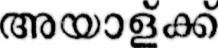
അയാള്ക്ക്
